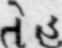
તેહ
